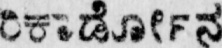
ರಿಕಾರ್ಡೋನ
